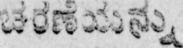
ಚರಣೆಯನ್ನು
